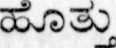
ಹೊತ್ತು
